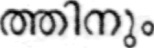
ത്തിനും
